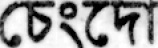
চেংদো
